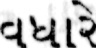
વધારે
